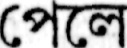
পেলে
